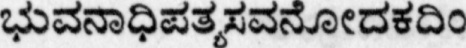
ಭುವನಾಧಿಪತ್ಯಸವನೋದಕದಿಂ
